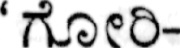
'ಗೋರಿ-
